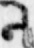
ને
